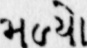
મળ્યો
